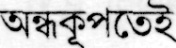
অন্ধকূপতেই
